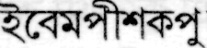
ইবেমপীশকপু
